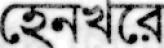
হেনখরে
